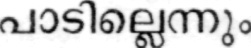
പാടില്ലെന്നും
